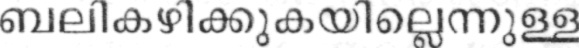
ബലികഴിക്കുകയില്ലെന്നുള്ള
